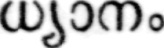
ധ്യാനം
